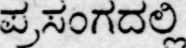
ಪ್ರಸಂಗದಲ್ಲಿ
